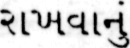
રાખવાનું
